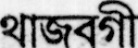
থাবগী
